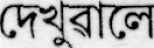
দেখুৱালে
